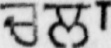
ਚਲਾ
